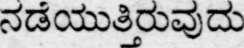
ನಡೆಯುತ್ತಿರುವುದು
